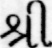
શ્રી
